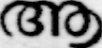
ആ
